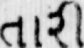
તારી
